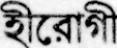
হীরোগী
